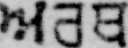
ਅਰਥ
